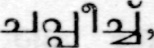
ചപ്പീച്ച്,
